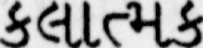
કલાત્મક
